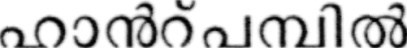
ഹാന്റ്പമ്പില്‍
